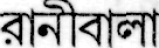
রানীবালা
